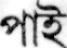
পাই
